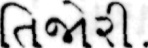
તિજોરી.
